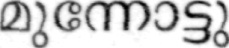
മുന്നോട്ടു
